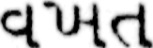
વખત
